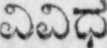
ವಿವಿಧ
